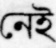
নেই
